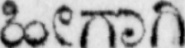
ಹೀಗಾಗಿ
